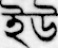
ইউ
